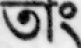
তাং
